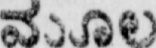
ಮೂಲ
